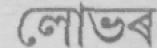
লোভৰ
